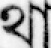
থা
